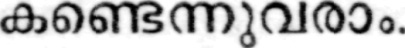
കണ്ടെന്നുവരാം.
